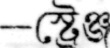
-স্ট্রেঞ্জ
